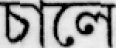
চালে
